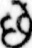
છે
